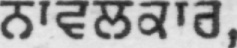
ਨਾਵਲਕਾਰ,
